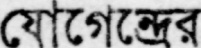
যোগেন্দ্রের
